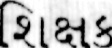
શિક્ષક
